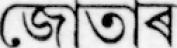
জোতাৰ
